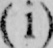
(i)
